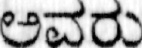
ಅವರು
